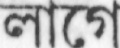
লাগে
